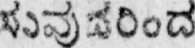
ಸುವುದರಿಂದ
